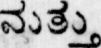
ಮತ್ತು
